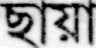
ছায়া
